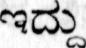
ಇದ್ದು
